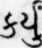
કર્યું
